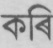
কৰি
